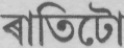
ৰাতিটো
